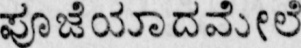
ಪೂಜೆಯಾದಮೇಲೆ
